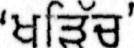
'ਖੜਿੱਚ'
